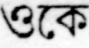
ওকে
